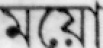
ময়ো
